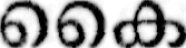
കൈ
